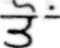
ਤੋਂ
